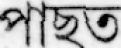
পাছত
